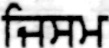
ਜਿਸਮ
